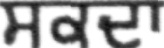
ਸਕਦਾ
